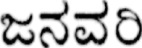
ಜನವರಿ
